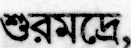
শুরমদ্রে,
